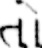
તો
